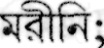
মরীনি;
